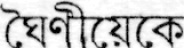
ঘৈণীয়েকে
